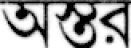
অস্তর
